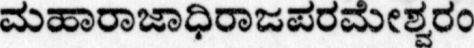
ಮಹಾರಾಜಾಧಿರಾಜಪರಮೇಶ್ವರಂ
